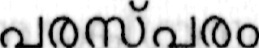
പരസ്പരം
